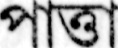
পাত্তা
